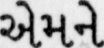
એમને
